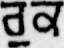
ਰੁਕ
